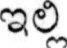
ಇಲ್ಲಿ
